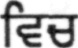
ਵਿਚ
